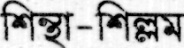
শিন্থা-শিল্লম
